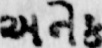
અનેક
